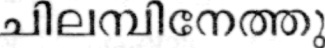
ചിലമ്പിനേത്തു
